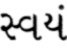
સ્વયં
